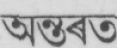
অন্তৰত
